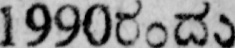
1990ರಂದು
